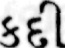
કદી
